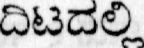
ದಿಟದಲ್ಲಿ
